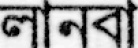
লানবা
